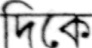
দিকে
